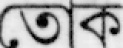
তোক
